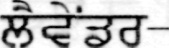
ਲੈਵੇਂਡਰ-
